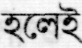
হলেই
